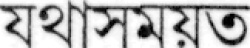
যথাসময়ত
